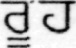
ਰੂਹ
